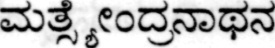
ಮತ್ಸ್ಯೇಂದ್ರನಾಥನ
